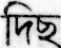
দিছ
